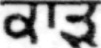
ਕਾੜ
